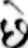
છે
